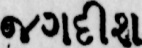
જગદીશ
